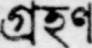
গ্রহণ
